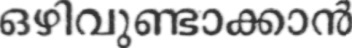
ഒഴിവുണ്ടാക്കാന്‍
